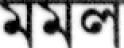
মমল
